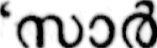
‘സാര്‍
